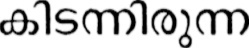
കിടന്നിരുന്ന
